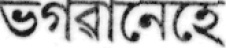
ভগৱানেহে
